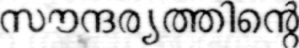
സൌന്ദര്യത്തിന്റെ
